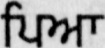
ਪਿਆ
